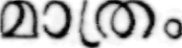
മാത്രം
